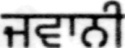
ਜਵਾਨੀ
